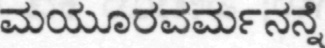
ಮಯೂರವರ್ಮನನ್ನೆ
